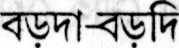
বড়দা-বড়দি
